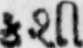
કશી
